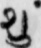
શું
